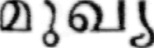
മുഖ്യ
